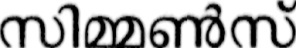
സിമ്മണ്‍സ്
